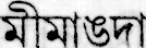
মীমাঙদা
